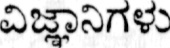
ವಿಜ್ಞಾನಿಗಳು
